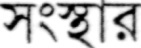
সংস্থার
